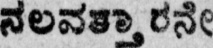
ನಲವತ್ತಾರನೇ
